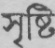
সৃষ্টি
